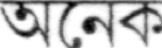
অনেক
